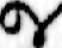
જ
